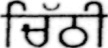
ਚਿੱਠੀ
